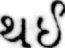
થઈ
